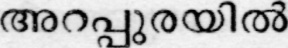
അറപ്പുരയില്‍
